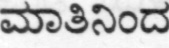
ಮಾತಿನಿಂದ
